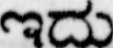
ಇದು
